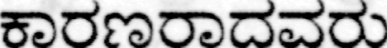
ಕಾರಣರಾದವರು
